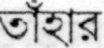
তাঁহার
